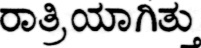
ರಾತ್ರಿಯಾಗಿತ್ತು
